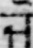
ਜੋ
